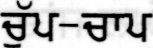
ਚੁੱਪ-ਚਾਪ
